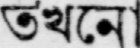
তখনো
